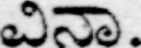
ವಿನಾ.
